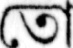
তো
